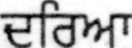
ਦਰਿਆ
